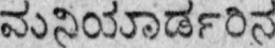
ಮನಿಯಾರ್ಡರಿನ
